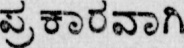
ಪ್ರಕಾರವಾಗಿ
